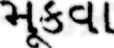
મૂકવા
